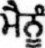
ਮੈਨੂੰ
